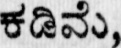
ಕಡಿಮೆ,
